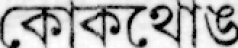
কোকথোঙ
